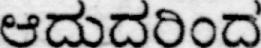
ಆದುದರಿಂದ
